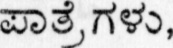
ಪಾತ್ರೆಗಳು,
